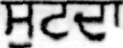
ਸੁਟਦਾ
